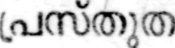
പ്രസ്തുത
